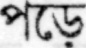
পড়ে
